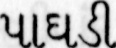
પાઘડી
